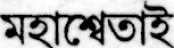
মহাশ্বেতাই
